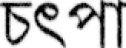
চৎপা
